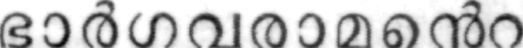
ഭാര്‍ഗവരാമന്റെ
